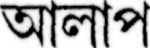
আলাপ
